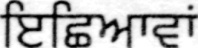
ਇਛਿਆਵਾਂ
